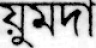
য়ুমদা
